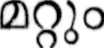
മറ്റും
